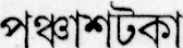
পঞ্চাশটকা
